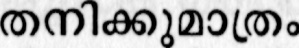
തനിക്കുമാത്രം
